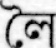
লৈ
